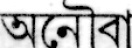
অনৌবা
